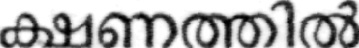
ക്ഷണത്തില്‍
